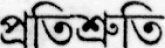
প্ৰতিশ্ৰুতি
